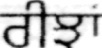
ਰੀਝਾਂ
